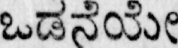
ಒಡನೆಯೇ
